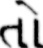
તો
